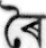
ৰৈ
